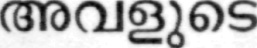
അവളുടെ
